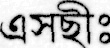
এসছীঃ
